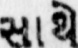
સાથે
